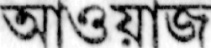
আওয়াজ
